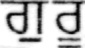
ਗੁਰੂ
